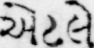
એટલે
